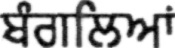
ਬੰਗਲਿਆਂ
